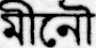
মীনৌ
